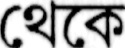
থেকে
